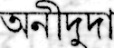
অনীদুদা
